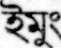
ইমুং
